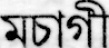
মচাগী
